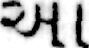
આ
